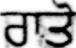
ਰਾਤੋ
